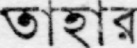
তাহার
